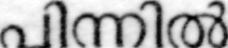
പിന്നില്‍
